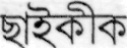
ছাইকীক
